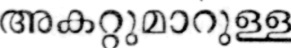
അകറ്റുമാറുള്ള
